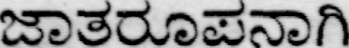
ಜಾತರೂಪನಾಗಿ
